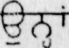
ਉਨ੍ਹਾਂ
